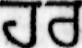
ਹਰ
